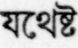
যথেষ্ট
